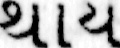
થાય
